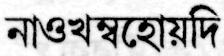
নাওখম্বহোয়দি
